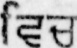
ਵਿਚ
